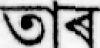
তাৰ
